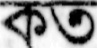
কত
